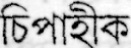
চিপাহীক
